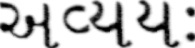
અવ્યયઃ
